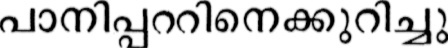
പാനിപ്പററിനെക്കുറിച്ചു
